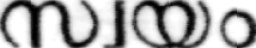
സ്വയം
